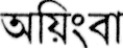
অয়িংবা
